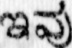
ಇವು
